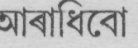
আৰাধিবো
